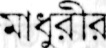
মাধুরীর
